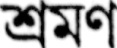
শ্রমণ
